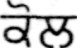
ਕੋਲ
